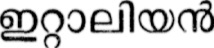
ഇറ്റാലിയന്‍
